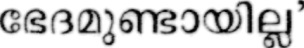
ഭേദമുണ്ടായില്ല'
